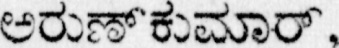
ಅರುಣ್‌ಕುಮಾರ್,
